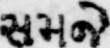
સમજે
